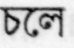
চলে
